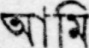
আমি
